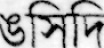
ঙসিদি
